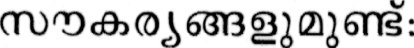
സൌകര്യങ്ങളുമുണ്ട്:
